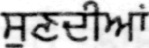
ਸੁਣਦੀਆਂ
